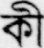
কী
